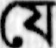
যে
